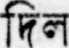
দিল
